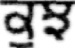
ਕੁਝ
